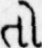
તો
